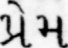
પ્રેમ
